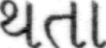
થતા
